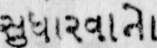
સુધારવાનો
